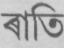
ৰাতি
